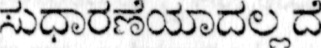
ಸುಧಾರಣೆಯಾದಲ್ಲದೆ
